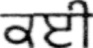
ਕਈ
